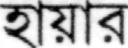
হায়ার
